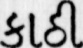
કાઠી
